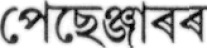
পেছেঞ্জাৰৰ
